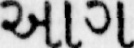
આગ
